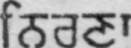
ਨਿਰਣਾ
